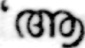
‘ആ
